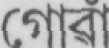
গোৱাঁ
